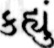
કહ્યું
